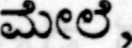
ಮೇಲೆ,
